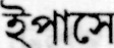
ইপাসে
